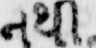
નથી.
